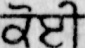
ਕੋਈ
